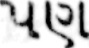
પણ
